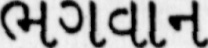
ભગવાન
